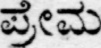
ಪ್ರೇಮ
